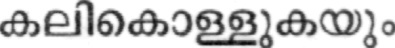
കലികൊള്ളുകയും
